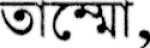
তাম্মো,
